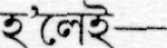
হ'লেই-
